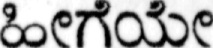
ಹೀಗೆಯೇ
